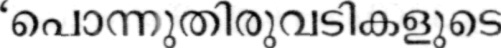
'പൊന്നുതിരുവടികളുടെ
